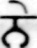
ਨੇ
